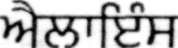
ਐਲਾਇੰਸ
